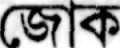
জোক
